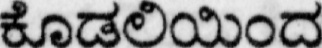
ಕೊಡಲಿಯಿಂದ
